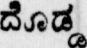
ದೊಡ್ಡ
